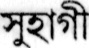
সুহাগী
